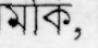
মকি,
